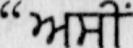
''ਅਸੀਂ
